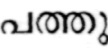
പത്തു
